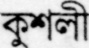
কুশলী
